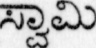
ಸ್ವಾಮಿ
